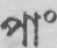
পা
